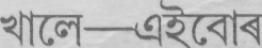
খালে-এইবোৰ
